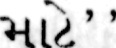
માટે"
